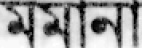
মমানা
